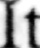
It
